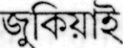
জুকিয়াই
